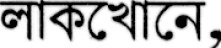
লাকখোনে,
